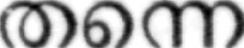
തന്നെ
